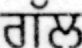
ਗੱਲ
